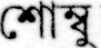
শোম্বু
